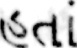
હતાં
